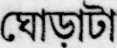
ঘোড়াটা
